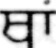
ਥਾਂ
